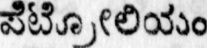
ಪೆಟ್ರೋಲಿಯಂ
